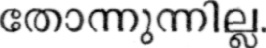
തോന്നുന്നില്ല.
